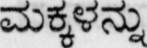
ಮಕ್ಕಳನ್ನು
